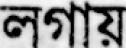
লগায়
